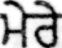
ਮੇਰੇ
